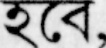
হবে,
